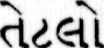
તેટલો
